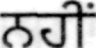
ਨਹੀਂ
